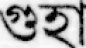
গুহা
